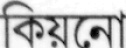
কিয়নো
